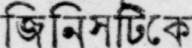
জিনিসটিকে
